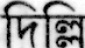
দিল্লি
